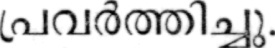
പ്രവര്‍ത്തിച്ചു.
